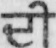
ਦੀ
